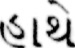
હાથે
